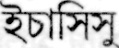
ইচাসিবু
